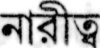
নারীত্ব
